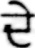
ਦੇ
